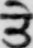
ਤੇ
